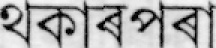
থকাৰপৰা
